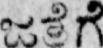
ಜತೆಗೆ
